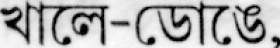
খালে-ডোঙে,
